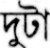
দুটা
